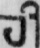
ਹੀ
